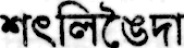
শৎলিঙৈদা
